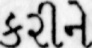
કરીને
